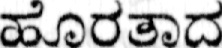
ಹೊರತಾದ
